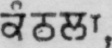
ਕੰਠਲਾ,
